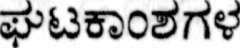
ಘಟಕಾಂಶಗಳ
